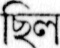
ছিল
